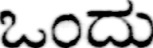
ಒಂದು
